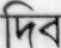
দিব
